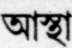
আস্থা
